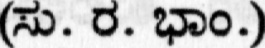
(ಸು.ರ.ಭಾಂ.)
